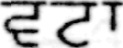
ਵਟਾ
